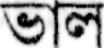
ভাল
